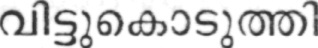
വിട്ടുകൊടുത്തി
